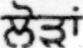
ਲੋੜਾਂ
